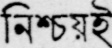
নিশ্চয়ই
